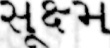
સૂક્ષ્મ
